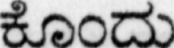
ಕೊಂದು
